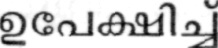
ഉപേക്ഷിച്ച്
